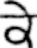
ਕੇ
